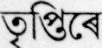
তৃপ্তিৰে
